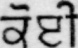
ਕੋਈ
